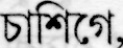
চাশিগে,
